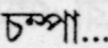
চম্পা...
